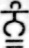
ਨੂੰ
